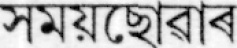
সময়ছোৱাৰ
